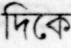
দিকে
